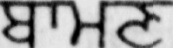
ਬਾਮਣ
